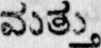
ಮತ್ತು
